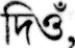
দিওঁ,
